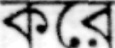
করে
